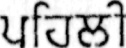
ਪਹਿਲੀ
